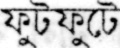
ফুটফুটে
